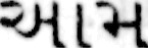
આમ
